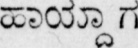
ಹಾಯ್ದಾಗ
